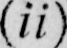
(ii)
